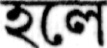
হলে
